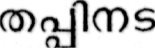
തപ്പിനട
